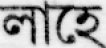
লাহে
